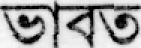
ভাবত
